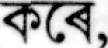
কৰে,
